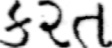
કરત
